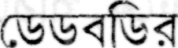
ডেডবডির
